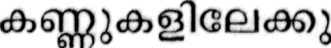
കണ്ണുകളിലേക്കു
